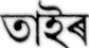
তাইৰ
